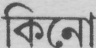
কিনো
